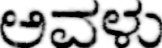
ಅವಳು
